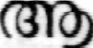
ആ
